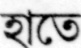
হাতে
